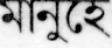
মানুহে
